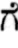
ಗೆ
